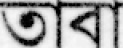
তাবা
